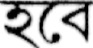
হবে
